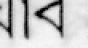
যাব
